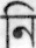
নি
